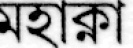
মহাক্না
